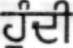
ਹੁੰਦੀ
